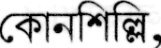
কোনশিল্লি,
